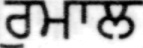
ਰੁਮਾਲ
